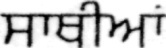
ਸਾਥੀਆਂ
